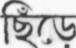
ছিঁড়ে
